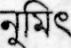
নুমিৎ
